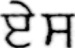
ਏਸ
